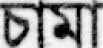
চামা
